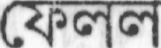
ফেলল
